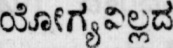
ಯೋಗ್ಯವಿಲ್ಲದ
